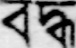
বদ্ধ
